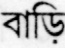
বাড়ি
